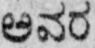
ಅವರ
